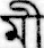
মী
